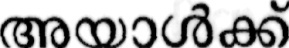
അയാള്‍ക്ക്
